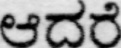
ಆದರೆ
